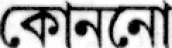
কোননো
